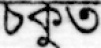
চকুত
